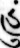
હું
